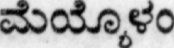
ಮೆಯ್ಯೊಳಂ
